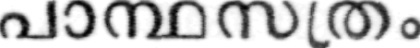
പാന്ഥസത്രം
